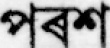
পৰশ
